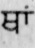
ਥਾਂ
